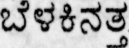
ಬೆಳಕಿನತ್ತ
